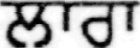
ਲਾਰਾ
